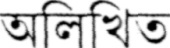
অলিখিত
